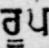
ਰੂਪ
